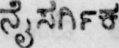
ನೈಸರ್ಗಿಕ
